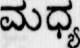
ಮಧ್ಯ
